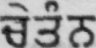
ਚੇਤੰਨ
